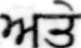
ਅਤੇ
